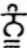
ਨੂੰ
